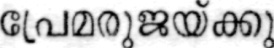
പ്രേമരുജയ്ക്കു
